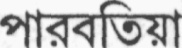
পারবতিয়া
